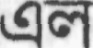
এল
